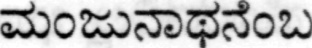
ಮಂಜುನಾಥನೆಂಬ
